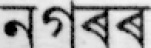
নগৰৰ
